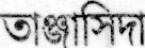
তাঞ্জাসিদা
